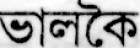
ভালকৈ
